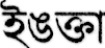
ইঙক্তা
